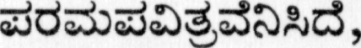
ಪರಮಪವಿತ್ರವೆನಿಸಿದೆ,
